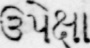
ઉપેક્ષા
